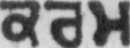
ਕਰਮ
